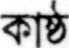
কাষ্ঠ
